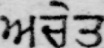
ਅਚੇਤ
